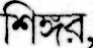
শিঙ্গর,
